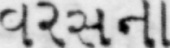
વરસના
